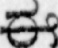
ಈ
